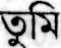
তুমি
